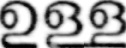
ഉള്ള
